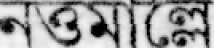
নত্তমাল্লে
